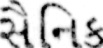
સૈનિક
